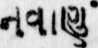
નવાણું
